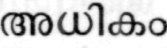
അധികം
